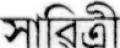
সাৱিত্রী
